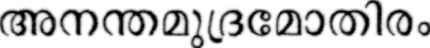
അനന്തമുദ്രമോതിരം
